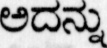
ಅದನ್ನು
